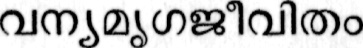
വന്യമൃഗജീവിതം
